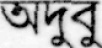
অদুবু
